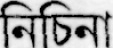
নিচিনা
